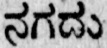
ನಗದು
